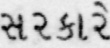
સરકારે
